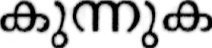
കുന്നുക
